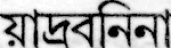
য়াদ্রবনিনা
